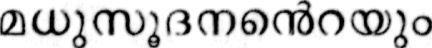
മധുസൂദനന്റെയും
